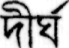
দীর্ঘ
